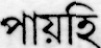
পায়হি
